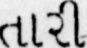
તારી
